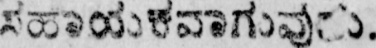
ಸಹಾಯಕವಾಗುವುದು.
